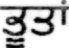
ਭੂਤਾਂ
